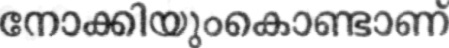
നോക്കിയുംകൊണ്ടാണ്
